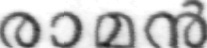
രാമന്‍
